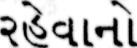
રહેવાનો
